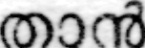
താന്‍
